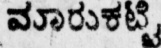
ಮಾರುಕಟ್ಟೆ
